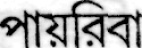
পায়রিবা
